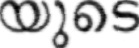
യുടെ
